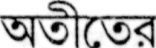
অতীতের
